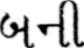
બની
